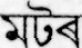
মটৰ
